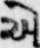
એ
